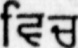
ਵਿਚ
